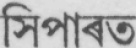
সিপাৰত
